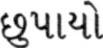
છુપાયો
